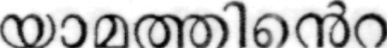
യാമത്തിന്റെ
